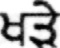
ਖੜੇ
